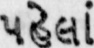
પહેલાં
